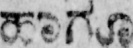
ಹಾಗೂ
